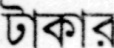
টাকার
